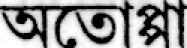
অতোপ্পা
